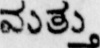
ಮತ್ತು
